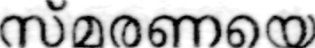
സ്മരണയെ
